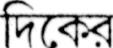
দিকের
